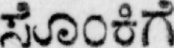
ಸೊಂಕಿಗೆ
